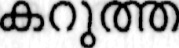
കറുത്ത
